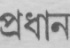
প্ৰধান
